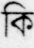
কি
